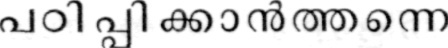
പഠിപ്പിക്കാന്‍ത്തന്നെ
